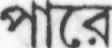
পারে
